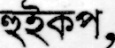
হুইকপ,
